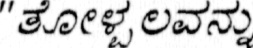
“ತೋಳ್ಬಲವನ್ನು
